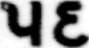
પદ
